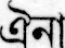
ঐনা
